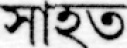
সাহত
